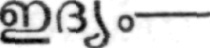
ഇദ്യം-
